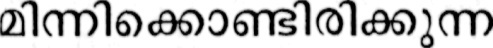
മിന്നിക്കൊണ്ടിരിക്കുന്ന
